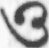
ও
